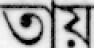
তায়
